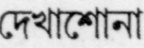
দেখাশোনা
